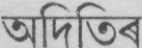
অদিতিৰ
